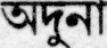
অদুনা
